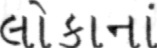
લોકાનાં
